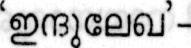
'ഇന്ദുലേഖ'-
